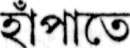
হাঁপাতে
